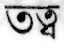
তত্ব
